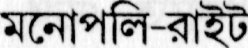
মনোপলি-রাইট
